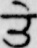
ਤੇ
